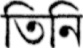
তিনি
